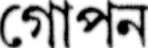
গোপন
